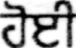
ਹੋਈ
